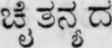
ಚೈತನ್ಯದ
